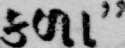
કળા”
